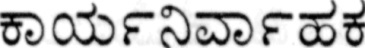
ಕಾರ್ಯನಿರ್ವಾಹಕ
